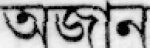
অজান
